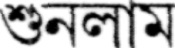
শুনলাম
